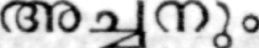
അച്ചനും
